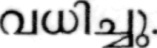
വധിച്ചു.
